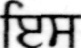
ਇਸ
